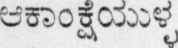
ಆಕಾಂಕ್ಷೆಯುಳ್ಳ
